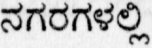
ನಗರಗಳಲ್ಲಿ
